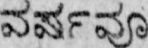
ವರ್ಷವೂ
